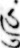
હું
